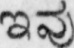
ಇವು
